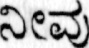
ನೀವು
